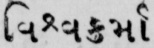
વિશ્વકર્મા
